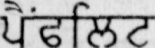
ਪੈਂਫਲਿਟ
